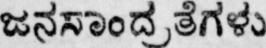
ಜನಸಾಂದ್ರತೆಗಳು
